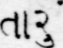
તારું
